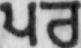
ਪਰ
